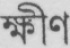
ক্ষীণ
